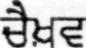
ਚੈਖ਼ਵ
